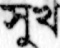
সুখ
